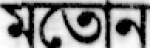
মতোন,
